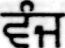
ਵੰਜ
